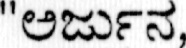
“ಅರ್ಜುನ,
